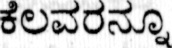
ಕೆಲವರನ್ನೂ
